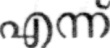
എന്ന്
